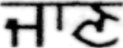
ਜਾਣ
